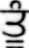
ਤੂੰ
